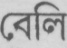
বেলি
